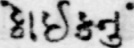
કોઈકનું
